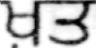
ਖ਼ਤ
